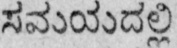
ಸಮಯದಲ್ಲಿ
